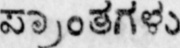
ಪ್ರಾಂತಗಳು
